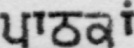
ਪਾਠਕਾਂ
